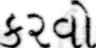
કરવો
